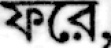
ফরে,
